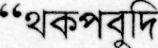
“থকপবুদি
